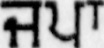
ਜਪਾ
